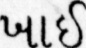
ખાઈ
